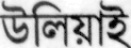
উলিয়াই
